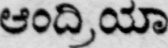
ಆಂದ್ರಿಯಾ
